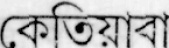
কেতিয়াবা
